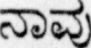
ನಾವು
